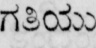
ಗತಿಯು
